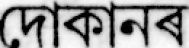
দোকানৰ
